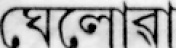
ঘেলোৱা
